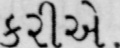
કરીએ.
